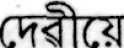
দেৱীয়ে
